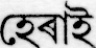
হেৰাই
